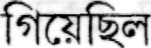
গিয়েছিল
